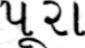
પૂરા
